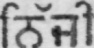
ਨਿੱਜੀ
